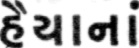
હેયાનાં
